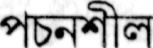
পচনশীল
